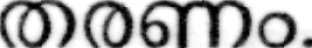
തരണം.
